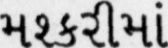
મશ્કરીમાં
